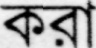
করা
